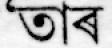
'তাৰ
